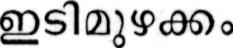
ഇടിമുഴക്കം
